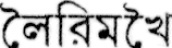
লৈরিমখৈ
